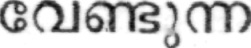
വേണ്ടുന്ന
